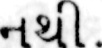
નથી.
